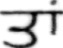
ਤਾਂ
